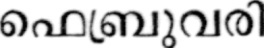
ഫെബ്രുവരി
